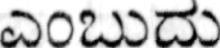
ಎಂಬುದು
